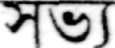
সভ্য
